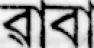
ৱাবা
